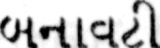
બનાવટી
